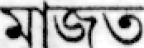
মাজত
